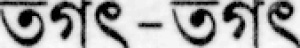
তগৎ-তগৎ
